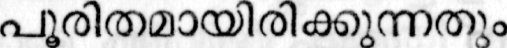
പൂരിതമായിരിക്കുന്നതും
